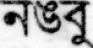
নঙবু
